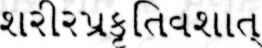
શરીરપ્રકૃતિવશાત્
